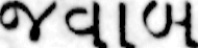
જવાબ
